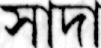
সাদা
